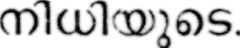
നിധിയുടെ.
